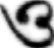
ও
